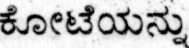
ಕೋಟೆಯನ್ನು
